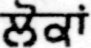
ਲੋਕਾਂ
